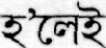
হ'লেই
